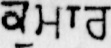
ਕੁਮਾਰ
